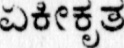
ಏಕೀಕೃತ
